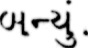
બન્યું.
